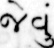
જેવું
